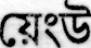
য়েংউ
